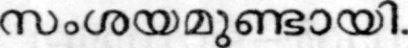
സംശയമുണ്ടായി.
